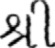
શ્રી
